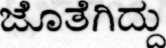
ಜೊತೆಗಿದ್ದು
